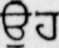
ਉਹ
